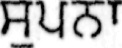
ਸੁਪਨਾ
